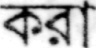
করা
